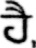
ਹੈ,
